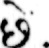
છે.
